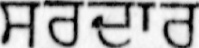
ਸਰਦਾਰ
